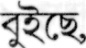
বুইছে,
